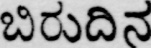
ಬಿರುದಿನ
